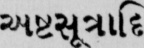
અષ્ટસૂત્રાદિ
